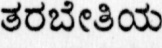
ತರಬೇತಿಯ
